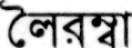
লৈরম্বা
